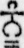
ਨੂੰ
